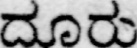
ದೂರು
